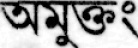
অমুক্তং
